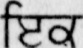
ਇਕ
